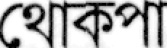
থোকপা
